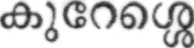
കുറേശ്ശെ
